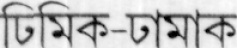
ঢিমিক-ঢামাক
